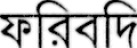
ফরিবদি
